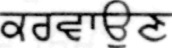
ਕਰਵਾਉਣ
